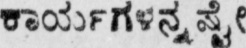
ಕಾರ್ಯಗಳನ್ನಷ್ಟೇ
